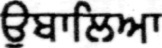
ਉਬਾਲਿਆ
